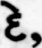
દે,
